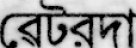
ৱেটরদা
